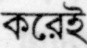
করেই
